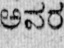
ಅವರ
